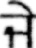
ਜੇ
